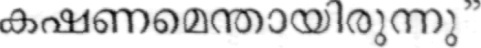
കഷണമെന്തായിരുന്നു”
